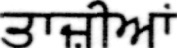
ਤਾਜ਼ੀਆਂ
